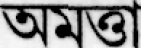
অমত্তা
